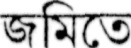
জমিতে
